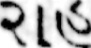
રાહ
